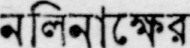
নলিনাক্ষের
